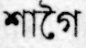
শাগৈ
